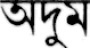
অদুম
